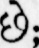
છે;
